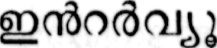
ഇന്‍റര്‍വ്യൂ
